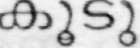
കൂടു
